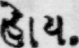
હોય.
